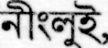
নীংলুই,
